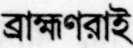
ব্রাহ্মণরাই
